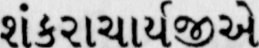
શંકરાચાર્યજીએ
